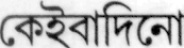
কেইবাদিনো
